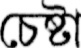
চেষ্টা
